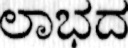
ಲಾಭದ
